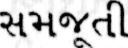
સમજૂતી
